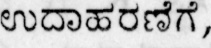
ಉದಾಹರಣೆಗೆ,
